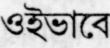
ওইভাবে
